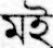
মই
